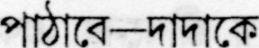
পাঠাবে—দাদাকে
